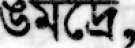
ঙমদ্রে,
